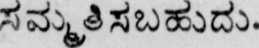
ಸಮ್ಮತಿಸಬಹುದು.
